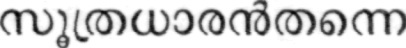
സൂത്രധാരന്‍തന്നെ
